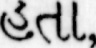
હતા,
